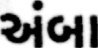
અંબા
